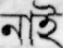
নাই
